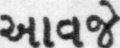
આવજે
